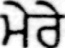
ਮੇਰੇ
